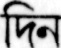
দিন
